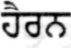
ਹੈਰਨ
